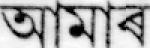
আমাৰ
